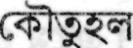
কৌতুহল
